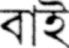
বাই
